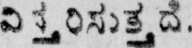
ವಿಸ್ತರಿಸುತ್ತದೆ.
